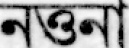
নত্তনা
